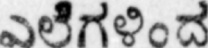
ಎಲೆಗಳಿಂದ
